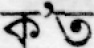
ক'ত
